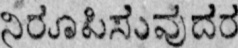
ನಿರೂಪಿಸುವುದರ
